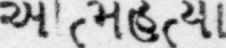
આત્મહત્યા
